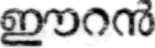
ഈറന്‍
